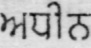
ਅਧੀਨ
